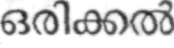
ഒരിക്കല്‍
